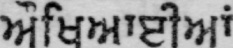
ਔਖਿਆਈਆਂ
